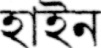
হাইন
